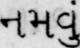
નમવું
